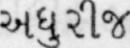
અધુરીજ
